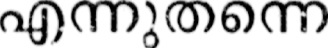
എന്നുതന്നെ
